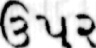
ઉપર
